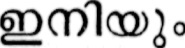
ഇനിയും
